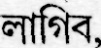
লাগিব,
